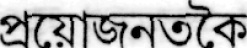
প্ৰয়োজনতকৈ
